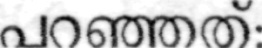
പറഞ്ഞത്:
